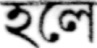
হলে
